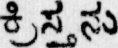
ಕ್ರಿಸ್ತನು
